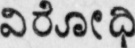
ವಿರೋಧಿ
